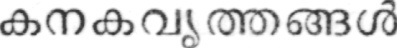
കനകവൃത്തങ്ങള്‍
